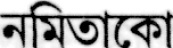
নমিতাকো
